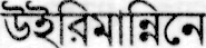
উইরিমান্নিনে
